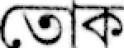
তোক
